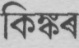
কিঙ্কৰ
